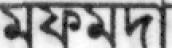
মফমদা
